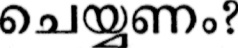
ചെയ്യണം?
